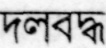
দলবদ্ধ
